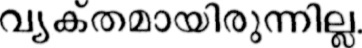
വ്യക്തമായിരുന്നില്ല.
